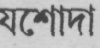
যশোদা
